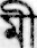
মী
